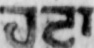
ਹਟਾ
